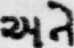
અને
